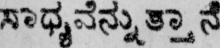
ಸಾಧ್ಯವೆನ್ನುತ್ತಾನೆ
